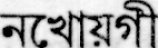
নখোয়গী
